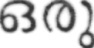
ഒരു
